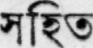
সহিত
